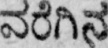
ವರೆಗಿನ
